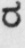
ರ
